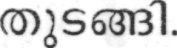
തുടങ്ങി.
